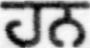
ਹਨ
